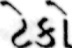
ટેકો
